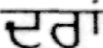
ਦਰਾਂ
